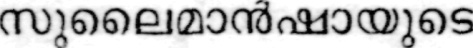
സുലൈമാന്‍ഷായുടെ
